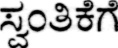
ಸ್ವಂತಿಕೆಗೆ
